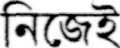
নিজেই
